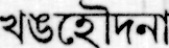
খঙহৌদনা
